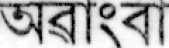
অৱাংবা
